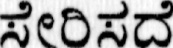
ಸೇರಿಸದೆ
